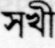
সখী
